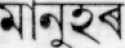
মানুহৰ
